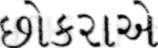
છોકરાએ
